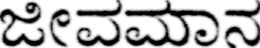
ಜೀವಮಾನ
